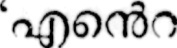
എൻെറ
